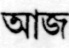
আজ
